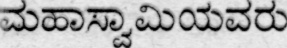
ಮಹಾಸ್ವಾಮಿಯವರು
